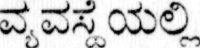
ವ್ಯವಸ್ಥೆಯಲ್ಲಿ
